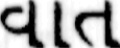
વાત
